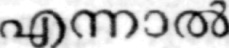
എന്നാല്‍
